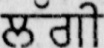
ਲੱਗੀ
